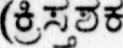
(ಕ್ರಿಸ್ತಶಕ
